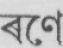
ৰণে
